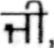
ਜੀ,
